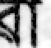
ৱা
